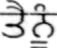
ਤੈਨੂੰ
